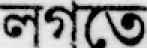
লগতে
